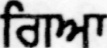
ਗਿਆ
